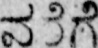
ವರೆಗೆ
